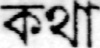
কথা
